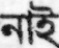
নাই
